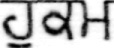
ਹੁਕਮ
